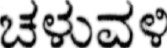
ಚಳುವಳಿ
